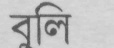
বুলি
